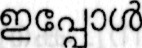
ഇപ്പോള്‍
